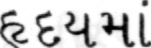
હ્રદયમાં
